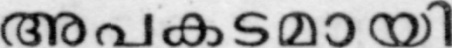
അപകടമായി
